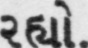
રહ્યો.
